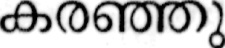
കരഞ്ഞു
